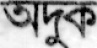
অদুক
